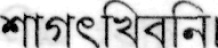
শাগৎখিবনি।
